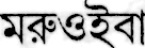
মরুওইবা
